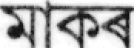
মাকৰ
